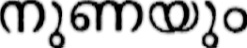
നുണയും
